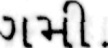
ગમી.
